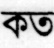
কত
